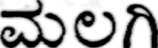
ಮಲಗಿ
